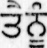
ਤੈਨੂੰ
